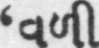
'વળી
